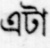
এটা
